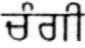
ਚੰਗੀ
